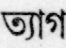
ত্যাগ
